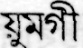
য়ুমগী
